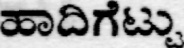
ಹಾದಿಗೆಟ್ಟು
